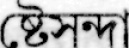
ষ্টেসন্দা
